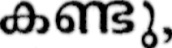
കണ്ടു,
